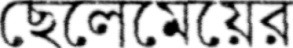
ছেলেমেয়ের
